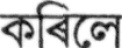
কৰিলে
